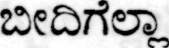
ಬೀದಿಗೆಲ್ಲಾ
